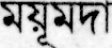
ময়ূমদা
